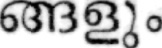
ങ്ങളും
